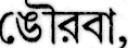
ঙৌরবা,
